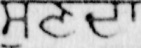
ਸੁਣਦਾ
